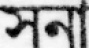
সনা
